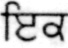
ਇਕ
